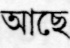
আছে
